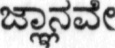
ಜ್ಞಾನವೇ
